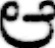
ಆ
